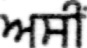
ਅਸੀਂ
